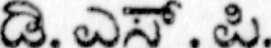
ಡಿ.ಎಸ್.ಪಿ.
